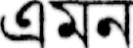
এমন
